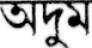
অদুম
